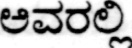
ಅವರಲ್ಲಿ
